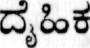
ದೈಹಿಕ
